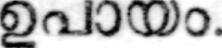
ഉപായം.
